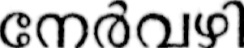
നേര്‍വഴി
